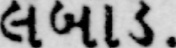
લબાડ.
